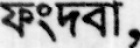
ফংদবা,
